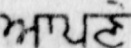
ਆਪਣੇ
